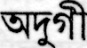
অদুগী
